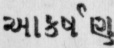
આકર્ષણ
